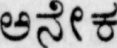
ಅನೇಕ
